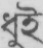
ধুই
